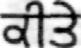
ਕੀਤੇ
